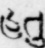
હતું
